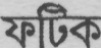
ফটিক
